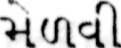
મેળવી
